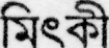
মিৎকী
